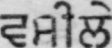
ਵਸੀਲੇ
